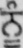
ਨੂੰ
